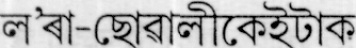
ল'ৰা-ছোৱালীকেইটাক
